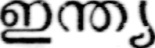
ഇന്ത്യ
